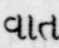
વાત
